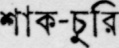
শাক-চুরি
